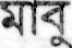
মাবু
